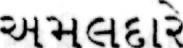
અમલદારે
